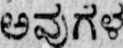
ಅವುಗಳ
